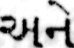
અને
